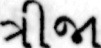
ત્રીજા
